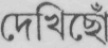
দেখিছোঁ
